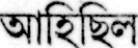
আহিছিল
